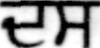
ਦਸ
